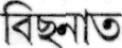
বিছনাত
